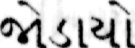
જોડાયો
